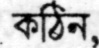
কঠিন,
